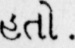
હતો.
